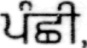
ਪੰਛੀ,
